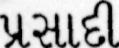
પ્રસાદી
